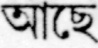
আছে
